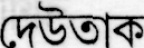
দেউতাক
